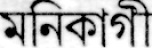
মনিকাগী
